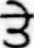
ਤੇ
